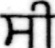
ਸੀ
